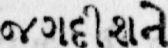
જગદીશને
